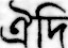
ঐদি
